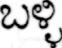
ಬಳ್ಳಿ
